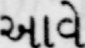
આવે
